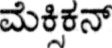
ಮೆಕ್ಸಿಕನ್
